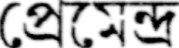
প্রেমেন্দ্র
